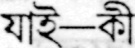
যাই—কী
